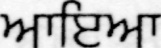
ਆਇਆ
